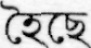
হৈছে
